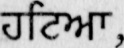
ਹਟਿਆ,
